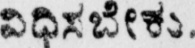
ವಿಧಿಸಬೇಕು.
